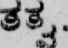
ತತ್ವ.
